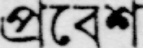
প্রবেশ
